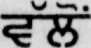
ਵੱਲੋਂ
